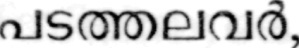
പടത്തലവര്‍,
